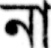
না
